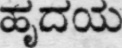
ಹೃದಯ
